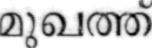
മുഖത്ത്
